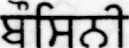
ਬੌਸਿਨੀ
